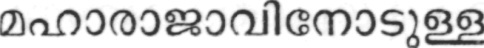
മഹാരാജാവിനോടുള്ള
